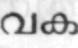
വക
